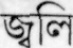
জ্বলি
